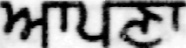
ਆਪਣਾ
